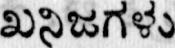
ಖನಿಜಗಳು
